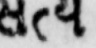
સત્ય
